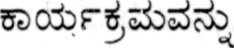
ಕಾರ್ಯಕ್ರಮವನ್ನು
